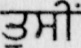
ਤੁਸੀਂ
